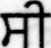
ਸੀ
